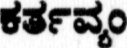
ಕರ್ತವ್ಯ೦
